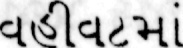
વહીવટમાં
